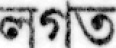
লগত
